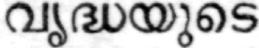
വൃദ്ധയുടെ
